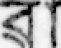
ৱা
